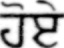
ਹੋਏ
